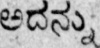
ಅದನ್ನು
